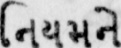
નિયમને
